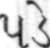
પડે
